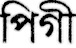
পিগী
